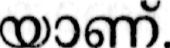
യാണ്.
